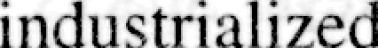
industrialized
